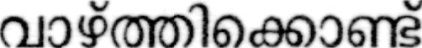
വാഴ്ത്തിക്കൊണ്ട്
